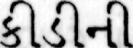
કીડીની
